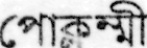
পোক্লম্মী
